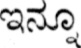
ಇನ್ನೂ
